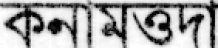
কনামত্তদা
